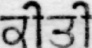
ਕੀਤੀ
